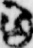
છે
